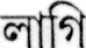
লাগি
